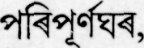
পৰিপূর্ণঘৰ,
